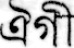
ঐগী
